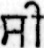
ਸੀ
